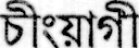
চীংয়াগী
